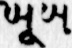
ખૂબ
